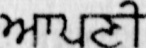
ਆਪਣੀ
